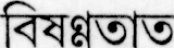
বিষণ্ণতাত
